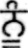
ਨੂੰ
